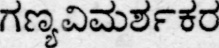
ಗಣ್ಯವಿಮರ್ಶಕರ
